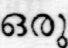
ഒരു
